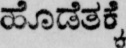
ಹೊಡೆತಕ್ಕೆ
